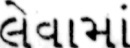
લેવામાં
